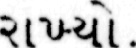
રાખ્યો.
